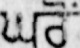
ਘਰੋਂ
